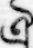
ঐ
